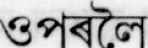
ওপৰলৈ
